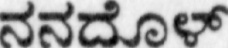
ನನದೊಳ್
